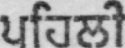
ਪਹਿਲੀ
